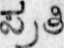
ಪ್ರತಿ
